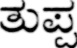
ತುಪ್ಪ
